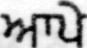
ਆਪੇ
